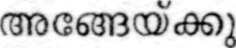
അങ്ങേയ്ക്കു
